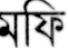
মফি
